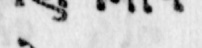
અણબનાવ
